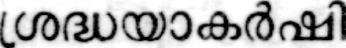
ശ്രദ്ധയാകര്‍ഷി
